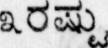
೩ರಷ್ಟು
